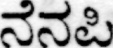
ನೆನಪಿ
